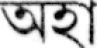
অহা
